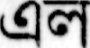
এল
